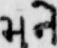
મને
